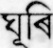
ঘূৰি
